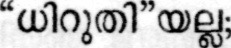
"ധിറുതി"യല്ല;
